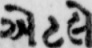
એટલે
